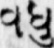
વધુ
